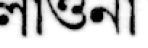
লাওনা
